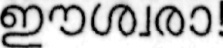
ഈശ്വരാ!
